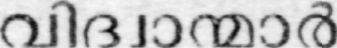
വിദ്വാന്മാര്‍
